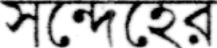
সন্দেহের
